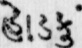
હોડકું
